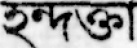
হন্দক্তা
